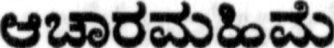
ಆಚಾರಮಹಿಮೆ
